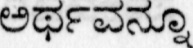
ಅರ್ಥವನ್ನೂ
